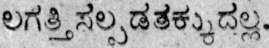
ಲಗತ್ತಿಸಲ್ಪಡತಕ್ಕುದಲ್ಲ.
